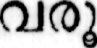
വരൂ
